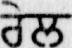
ਰੇਲ
